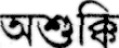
অশুক্কি
